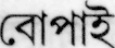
বোপাই
